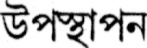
উপস্থাপন
